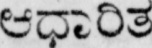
ಆಧಾರಿತ
